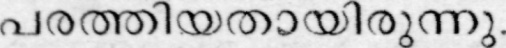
പരത്തിയതായിരുന്നു.
